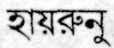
হায়রুনু
